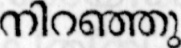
നിറഞ്ഞു
